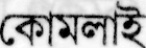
কোমলাই
